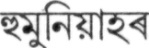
হুমুনিয়াহৰ
